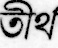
তীর্থ
